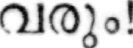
വരും!
